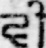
ਵੀ
